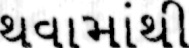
થવામાંથી
